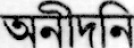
অনীদনি
